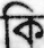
কি
